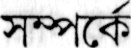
সম্পর্কে
